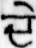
ਦੇ
